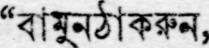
‘‘বামুঠাকরুন,
